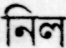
নিল
